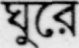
ঘুরে
